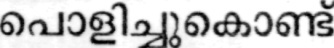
പൊളിച്ചുകൊണ്ട്
